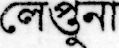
লেপ্তুনা
